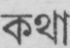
কথা
